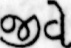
જીવે
